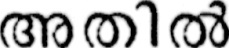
അതില്‍
